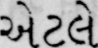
એટલે
